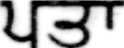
ਪਤਾ
